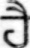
ਹੈ
